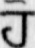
ਹੋ
